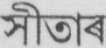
সীতাৰ
